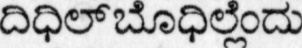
ದಿಧಿಲ್ಬೊಧಿಲ್ಲೆಂದು
